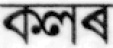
কলৰ
